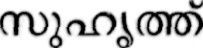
സുഹൃത്ത്
